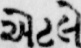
એટલે
